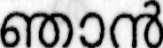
ഞാന്‍
